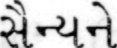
સૈન્યને
